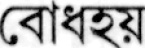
বোধহয়
